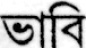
ভাবি
